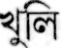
খুলি
